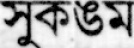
সুকঙম
